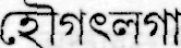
হৌগৎলগা
